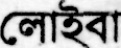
লোইবা
